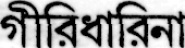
গীরিধারিনা
